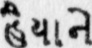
હૈયાને
